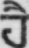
ਹੈ
